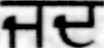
ਜਦ
